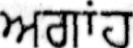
ਅਗਾਂਹ
